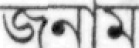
জনাম
